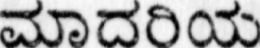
ಮಾದರಿಯ
